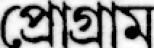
প্রোগ্রাম
